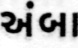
અંબા
